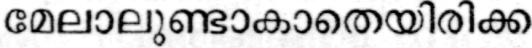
മേലാലുണ്ടാകാതെയിരിക്ക
